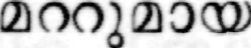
മററുമായ
